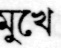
মুখে
